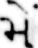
મેં
